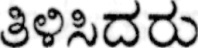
ತಿಳಿಸಿದರು
